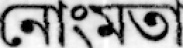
নোংমতা
